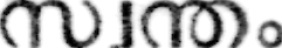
സ്വന്തം
